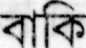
বাকি
